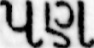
પણ
